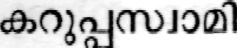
കറുപ്പസ്വാമി
